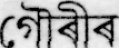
গৌৰীৰ
